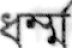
ধর্ম্ম
